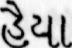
હૈયા
